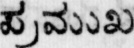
ಪ್ರಮುಖ
